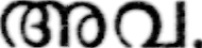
അവ.
